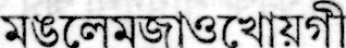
মঙলেমজাওখোয়গী
